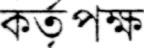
কর্তৃপক্ষ
